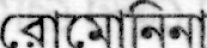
রোমোনিনা
